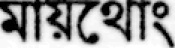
মায়থোং
